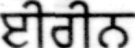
ਈਰੀਨ
